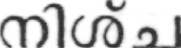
നിശ്ച
